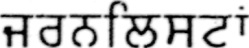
ਜਰਨਲਿਸਟਾਂ
